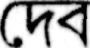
দেব
